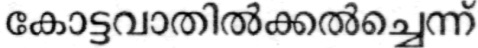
കോട്ടവാതില്‍ക്കല്‍ച്ചെന്ന്
